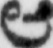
ಆ
